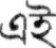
এই
